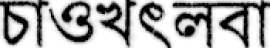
চাওখৎলবা
